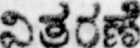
ವಿತರಣೆ
